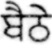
ਬੈਠੇ
